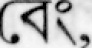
বেং,
